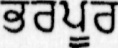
ਭਰਪੂਰ
